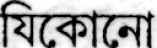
যিকোনো
